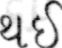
થઈ
